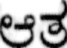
ಆತ
